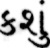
કશું
